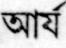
আর্য
